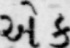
એક
